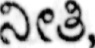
ನೀತಿ,
